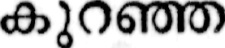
കുറഞ്ഞ
